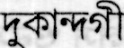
দুকান্দগী
